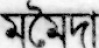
মমৈদা
